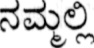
ನಮ್ಮಲ್ಲಿ
